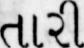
તારી
